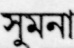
সুমনা
